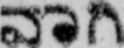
ವಾಗಿ
